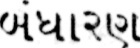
બંધારણ
